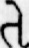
તે
